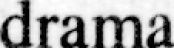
drama
